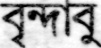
বৃন্দাবু
